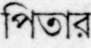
পিতার
